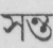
সন্ত
